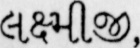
લક્ષ્મીજી,
